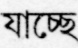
যাচ্ছে
